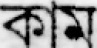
কাম
